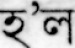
হ'ল
